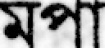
মপা
